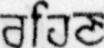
ਰਹਿਣ
